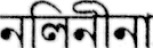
নলিনীনা
